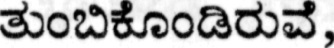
ತುಂಬಿಕೊಂಡಿರುವೆ,
